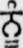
ਨੂੰ
